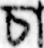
চা
